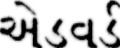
એડવર્ડ
